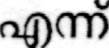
എന്ന്
